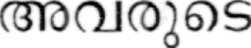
അവരുടെ
